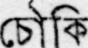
চৌকি
